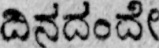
ದಿನದಂದೇ
